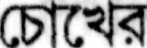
চোখের
